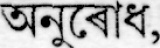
অনুৰোধ,
